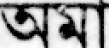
অমা
